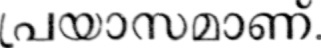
പ്രയാസമാണ്.
